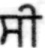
ਸੀ
